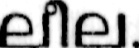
ലീല.
